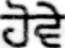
ਹੋਵੇ
